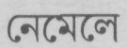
নেমেলে
